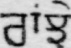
ਰਾਂਝੇ
